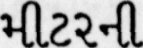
મીટરની
